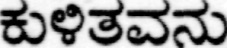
ಕುಳಿತವನು
